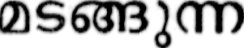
മടങ്ങുന്ന
